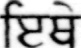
ਇਥੇ
